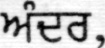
ਅੰਦਰ,
